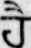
ਹੈ
